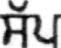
ਸੱਪ
